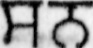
ਸਨ
